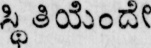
ಸ್ಥಿತಿಯೆಂದೇ
